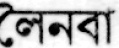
লৈনবা
